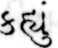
કહ્યું
